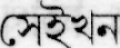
সেইখন
